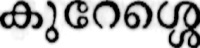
കുറേശ്ശെ
